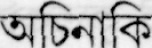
অচিনাকি
